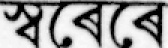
স্বৰেৰে
